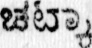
ಚಟ್ಕಾ
